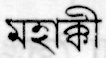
মহাক্কী
